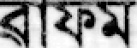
ৱাফম
